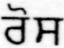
ਰੋਸ
